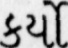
કર્યો
